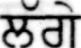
ਲੱਗੇ
